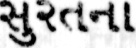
સુરતના
